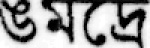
ঙমদ্রে
